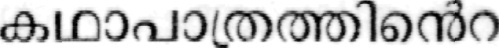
കഥാപാത്രത്തിന്റെ
